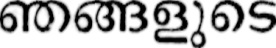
ഞങ്ങളുടെ
